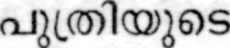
പുത്രിയുടെ
